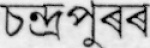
চন্দ্রপুৰৰ
